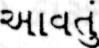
આવતું
